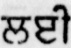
ਲਈ
